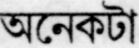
অনেকটা
